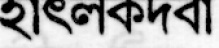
হাৎলকদবা
